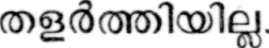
തളര്‍ത്തിയില്ല.
